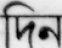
দিন
